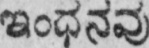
ಇಂಧನವು
